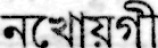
নখোয়গী
